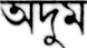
অদুম
